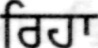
ਰਿਹਾ
